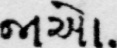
જાઓ.
